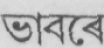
ভাবৰে
